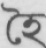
হৈ
